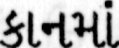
કાનમાં
